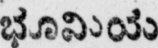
ಭೂಮಿಯ
